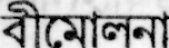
বীমোলনা
